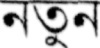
নতুন
